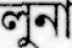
লুনা
